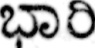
ಭಾರಿ
